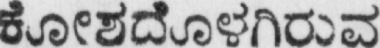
ಕೋಶದೊಳಗಿರುವ
